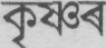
কৃষ্ণৰ
